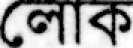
লোক
